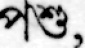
পশু,
